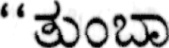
"ತುಂಬಾ
